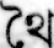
থৈ
